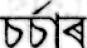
চর্চাৰ
